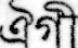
ঐগী
